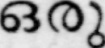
ഒരു
